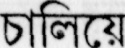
চালিয়ে
